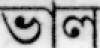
ভাল
